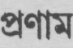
প্ৰণাম
